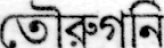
তৌরুগনি
